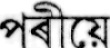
পৰীয়ে
